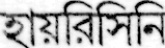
হায়রিসিনি
